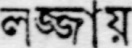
লজ্জায়
